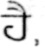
ਹੈ,
